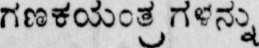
ಗಣಕಯಂತ್ರಗಳನ್ನು
